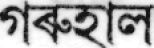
গৰুহাল
